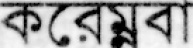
করেম্নবা
